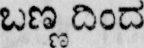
ಬಣ್ಣದಿಂದ
